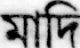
মাদি
